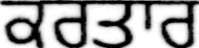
ਕਰਤਾਰ
